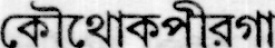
কৌথোকপীরগা
